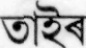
তাইৰ
